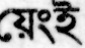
য়েংই
